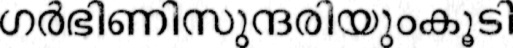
ഗര്‍ഭിണിസുന്ദരിയുംകൂടി
